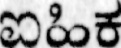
ಐಹಿಕ
